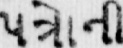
પત્રોની
